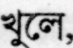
খুলে,
